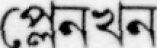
প্লেনখন
